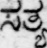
ಸತ್ಯ
